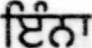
ਇੰਨਾ
